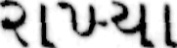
રાખ્યા
